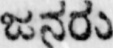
ಜನರು
